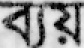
ব্যয়
